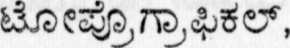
ಟೋಪ್ರೊಗ್ರಾಫಿಕಲ್,
